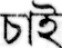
চাই
